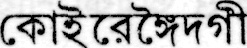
কোইরেঙ্গৈদগী
